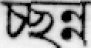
চ্ছন্ন
